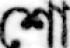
শো
